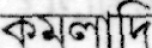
কমলাদি
